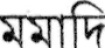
মমাদি
